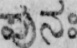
ಪುನಃ
